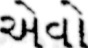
એવો
